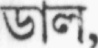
ডাল,
